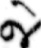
જે
